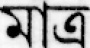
মাত্র
